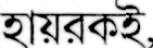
হায়রকই,
